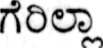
ಗೆರಿಲ್ಲಾ
